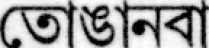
তোঙানবা
